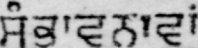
ਸੰਭਾਵਨਾਵਾਂ
